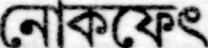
নোকফেৎ
